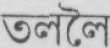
তললৈ
